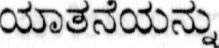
ಯಾತನೆಯನ್ನು
